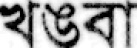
নুংথিলদি
